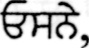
ਓਸਨੇ,
